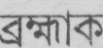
ব্ৰহ্মাক
